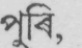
পুৰি,
